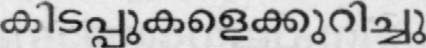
കിടപ്പുകളെക്കുറിച്ചു
